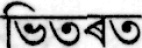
ভিতৰত
